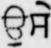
ਉਸੇ
